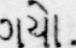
ગયો.
